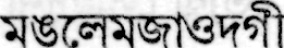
মঙলেমজাওদগী
